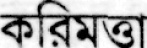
করিমত্তা
